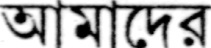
আমাদের
